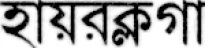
হায়রক্লগা
